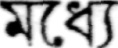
মধ্যে
